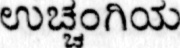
ಉಚ್ಚಂಗಿಯ
